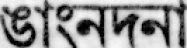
ঙাংনদনা
